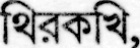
থিরকখি,
